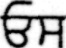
ਓਸ
